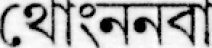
থোংননবা
